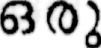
ഒരു
